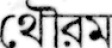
থৌরম
